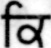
ਕਿ
